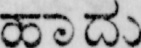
ಹಾದು
